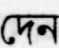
দেন
